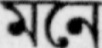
মনে
